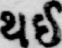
થઈ
